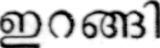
ഇറങ്ങി
